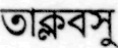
তাক্লবসু
